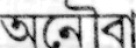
অনৌবা
